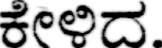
ಕೇಳಿದ.
